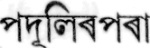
পদূলিৰপৰা
